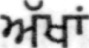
ਅੱਖਾਂ
